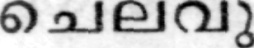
ചെലവു
